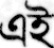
এই
